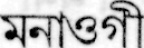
মনাওগী
